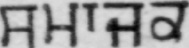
ਸਮਾਜਕ
